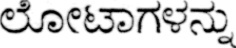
ಲೋಟಾಗಳನ್ನು
